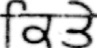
ਕਿਤੇ
